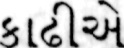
કાઢીએ
